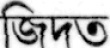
জিদত
